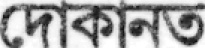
দোকানত
